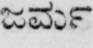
ಜರ್ಮ
